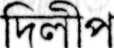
দিলীপ
